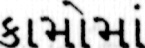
કામોમાં
